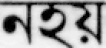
নহয়
